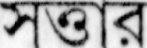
সত্তার
